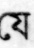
যে
